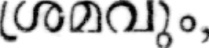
ശ്രമവും,
